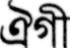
ঐগী
